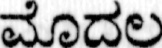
ಮೊದಲ
